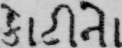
કોટીનો
